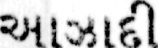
આઝાદી
